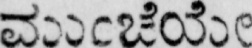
ಮುಂಚೆಯೇ
